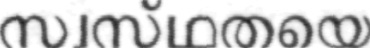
സ്വസ്ഥതയെ
